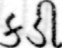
કડી
